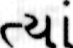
ત્યાં
